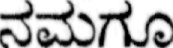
ನಮಗೂ
